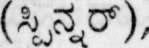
(ಸ್ಪಿನ್ನರ್),
